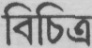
বিচিত্র
